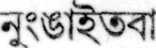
নুংঙাইতবা
